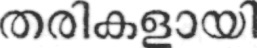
തരികളായി
